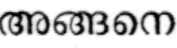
അങ്ങനെ
